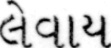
લેવાય
